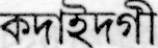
কদাইদগী
